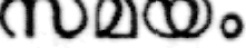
സമയം
